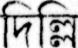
দিল্লি
